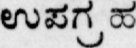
ಉಪಗ್ರಹ
